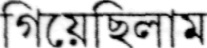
গিয়েছিলাম
